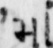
માં
